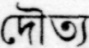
দৌত্য
